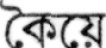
কৈয়ে
